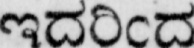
ಇದರಿಂದ
